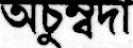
অচুম্বদা
